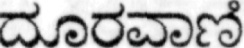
ದೂರವಾಣಿ
